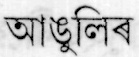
আঙুলিৰ
